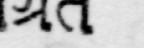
જાગ્રત
